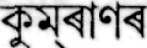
কুম্‌ৰাণৰ
